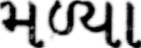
મળ્યા
